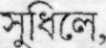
সুধিলে,
